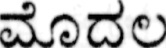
ಮೊದಲ
